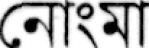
নোংমা
